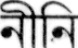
নীনি
